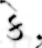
કે,
